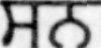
ਸਨ
